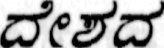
ದೇಶದ
